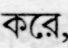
করে,
